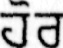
ਹੋਰ
